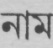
নাম
